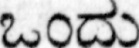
ಒಂದು
